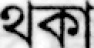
থকা
